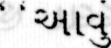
"આવું
